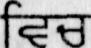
ਵਿਚ
